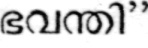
ഭവന്തി”
